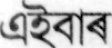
এইবাৰ
